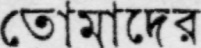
তোমাদের
